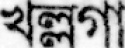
খল্লগা
